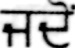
ਜਦੋਂ
